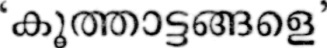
'കൂത്താട്ടങ്ങളെ'
